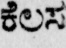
ಕೆಲಸ
